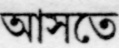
আসতে
